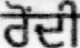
ਰੋਂਦੀ
